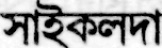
সাইকলদা
